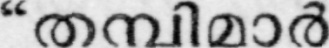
"തമ്പിമാര്‍
